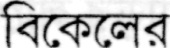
বিকেলের
